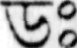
ডঃ
